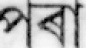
পৰা
